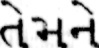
તેમને
